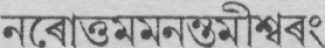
নৰোত্তমমনন্তমীশ্বৰং
